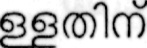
ള്ളതിന്
